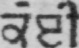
ਕੋਈ
